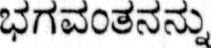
ಭಗವಂತನನ್ನು
